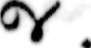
જ.
